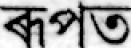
ৰূপত
